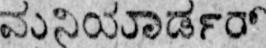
ಮನಿಯಾರ್ಡರ್
